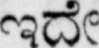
ಇದೇ
